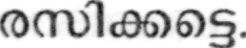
രസിക്കട്ടെ.
